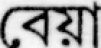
বেয়া
